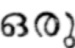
ഒരു
